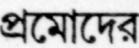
প্রমোদের
